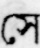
সে
